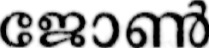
ജോണ്‍
